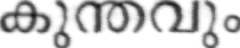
കുന്തവും
